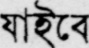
যাইবে
